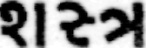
શસ્ત્ર
